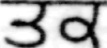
ਤਕ
